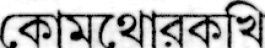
কোমথোরকখি
